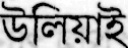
উলিয়াই
